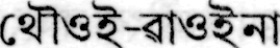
থৌওই-ৱাওইনা
